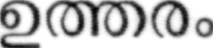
ഉത്തരം
